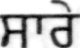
ਸਾਰੇ
